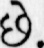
છે.
